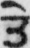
ਤੇ
